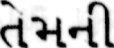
તેમની
